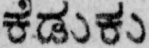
ಕೆಡುಕು
